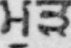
ਮੁੜ
